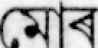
মোৰ
